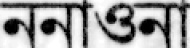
ননাওনা
